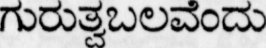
ಗುರುತ್ವಬಲವೆಂದು
